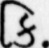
કિ.
